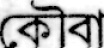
কৌবা
